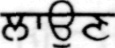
ਲਾਉਣ
